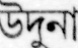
উদুনা
